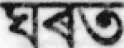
ঘৰত
